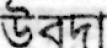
উবদা
